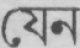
যেন
